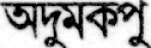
অদুমকপু
